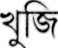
খুজি
